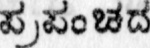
ಪ್ರಪಂಚದ
